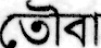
তৌবা
